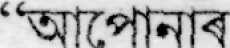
"আপোনাৰ
